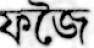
ফজৈ
